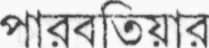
পারবতিয়ার
